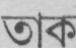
তাক
